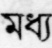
মধ্য
